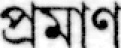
প্রমাণ
